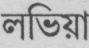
লভিয়া
